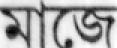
মাজে
